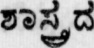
ಶಾಸ್ತ್ರದ
